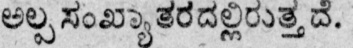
ಅಲ್ಪಸಂಖ್ಯಾತರದಲ್ಲಿರುತ್ತದೆ.
